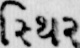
સ્થિર
